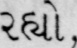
રહ્યો,
